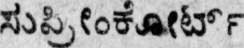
ಸುಪ್ರೀಂಕೋರ್ಟ್
